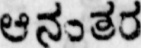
ಆನಂತರ
